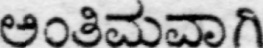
ಅಂತಿಮವಾಗಿ
